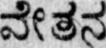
ವೇತನ
